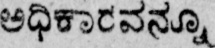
ಅಧಿಕಾರವನ್ನೂ
